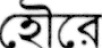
হৌরে
